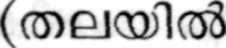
(തലയില്‍
